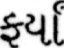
ફર્યાં
